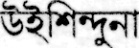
উইশিন্দুনা
